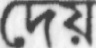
দেয়
